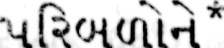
પરિબળોને✶
